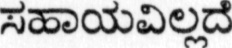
ಸಹಾಯವಿಲ್ಲದೆ
